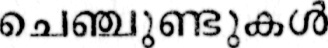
ചെഞ്ചുണ്ടുകള്‍
